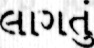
લાગતું
